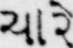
ચારે
